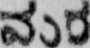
ಮರ
